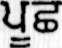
ਪੂਛ
